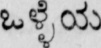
ಒಳ್ಳೆಯ
